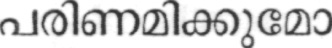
പരിണമിക്കുമോ
